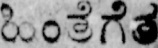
ಹಿಂತೆಗೆತ
